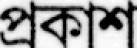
প্ৰকাশ
